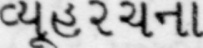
વ્યૂહરચના
